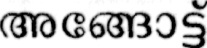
അങ്ങോട്ട്
